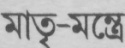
মাতৃ-মন্ত্ৰে
